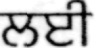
ਲਈ
